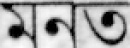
মনত
